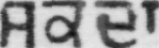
ਸਕਦਾ
